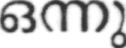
ഒന്നു
